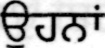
ਉਹਨਾਂ
